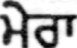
ਮੇਰਾ
